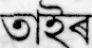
তাইৰ
